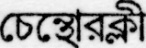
চেন্থোরক্লী
